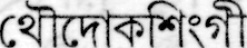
থৌদোকশিংগী
